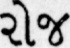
રોજ
